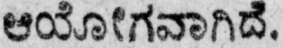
ಆಯೋಗವಾಗಿದೆ.
